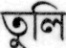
তুলি
